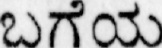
ಬಗೆಯ
